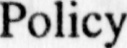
Policy
